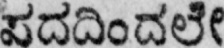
ಪದದಿಂದಲೇ
